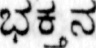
ಭಕ್ತನ
